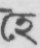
হৈ
